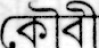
কৌবী
